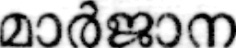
മാര്‍ജാന
